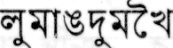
লুমাঙদুমখৈ
